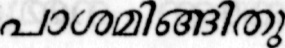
പാശമിങ്ങിതു
